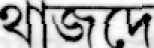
থাজদে
